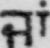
ਜਾਂ
